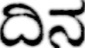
ದಿನ
